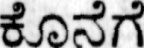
ಕೊನೆಗೆ
